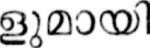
ളുമായി
